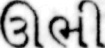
ઊભી
